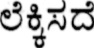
ಲೆಕ್ಕಿಸದೆ
